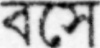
বসে
